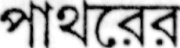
পাথরের
